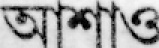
আশাও
